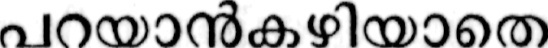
പറയാന്‍കഴിയാതെ
